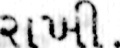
રાખી.
